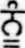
ਨੂੰ
